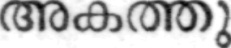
അകത്തു
